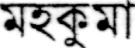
মহকুমা
